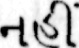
નહીં
